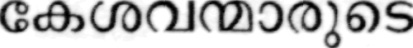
കേശവന്മാരുടെ
